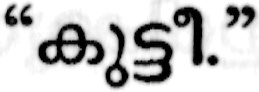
“കുട്ടീ.”
